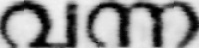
വന്ന
